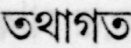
তথাগত
